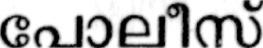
പോലീസ്
